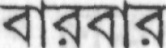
বারবার
